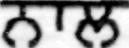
ਨਾਲ
